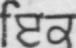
ਇਕ
